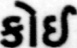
કોઈ
